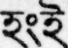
হংই
